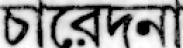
চারেদনা
